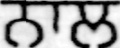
ਨਾਲ
